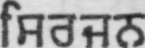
ਸਿਰਜਨ
